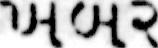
ખબર
